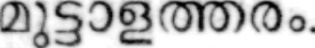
മുട്ടാളത്തരം.
